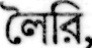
লৈরি,
